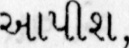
આપીશ,
